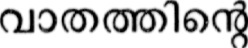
വാതത്തിന്റെ
